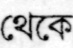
থেকে
